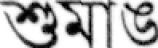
শুমাঙ
